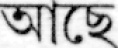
আছে
